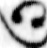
ও
